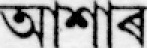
আশাৰ
